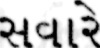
સવારે
